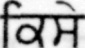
ਕਿਸੇ
